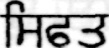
ਸਿਫਤ
